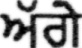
ਅੱਗੇ
